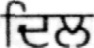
ਦਿਲ
